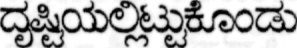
ದೃಷ್ಟಿಯಲ್ಲಿಟ್ಟುಕೊಂಡು
